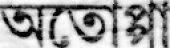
অতোপ্পা
